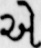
એ
